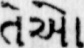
તેઓ
